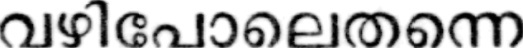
വഴിപോലെതന്നെ
